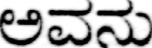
ಅವನು
